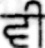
ਵੀ
